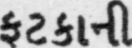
ફટકાની
